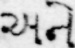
અને
